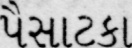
પૈસાટકા
